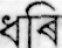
ধৰি
